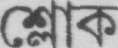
শ্লোক
